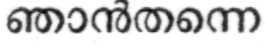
ഞാന്‍തന്നെ
